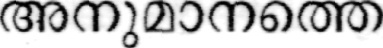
അനുമാനത്തെ
